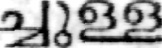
ച്ചുള്ള
